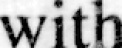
with
